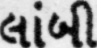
લાંબી
